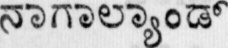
ನಾಗಾಲ್ಯಾಂಡ್
